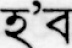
হ'ব
